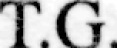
T.G.
